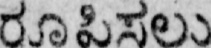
ರೂಪಿಸಲು
